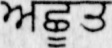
ਅਛੂਤ
